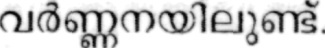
വര്‍ണ്ണനയിലുണ്ട്.
